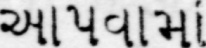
આપવામાં
